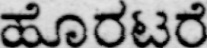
ಹೊರಟರೆ
